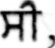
ਸੀ,
